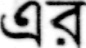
এর
